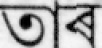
তাৰ
